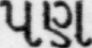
પણ
